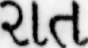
રાત
